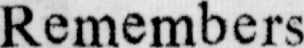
Remembers
